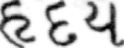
હ્રદય
